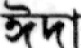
ঈদা
